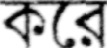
করে
